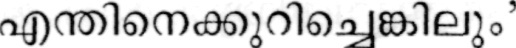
എന്തിനെക്കുറിച്ചെങ്കിലും'
